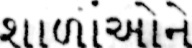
શાળાંઓને
